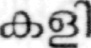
കളി
